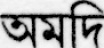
অমদি
